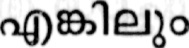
എങ്കിലും
